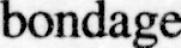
bondage
